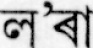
ল'ৰা
